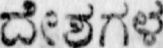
ದೇಶಗಳ
